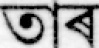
তাৰ
